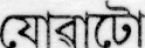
যোৱাটো
